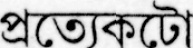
প্রত্যেকটো
